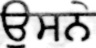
ਉਸਨੇ
